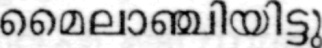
മൈലാഞ്ചിയിട്ടു
